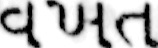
વખત
